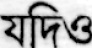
যদিও
